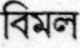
বিমল
